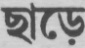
ছাড়ে
